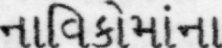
નાવિકોમાંના
